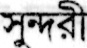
সুন্দরী
